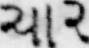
ચાર
